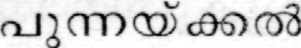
പുന്നയ്ക്കല്‍
